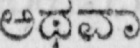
ಅಥವಾ
